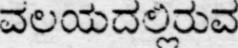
ವಲಯದಲ್ಲಿರುವ
